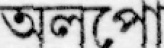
অলপো
